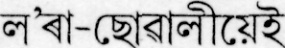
ল'ৰা-ছোৱালীয়েই
